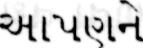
આપણને
